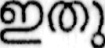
ഇതു
